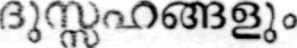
ദുസ്സഹങ്ങളും
